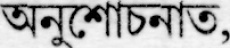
অনুশোচনাত,
